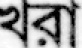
খরা
